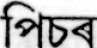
পিচৰ
